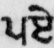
ਪਏ
